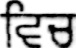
ਵਿਚ
